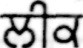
ਲੀਕ
